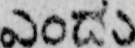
ಎಂದು
